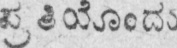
ಪ್ರತಿಯೊಂದು
